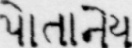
પોતાનેય
